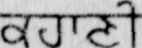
ਕਹਾਣੀ
